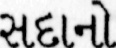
સદાનો
